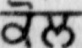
ਕੋਲ
